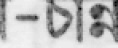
চান্ন
